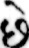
છે
